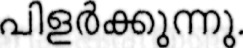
പിളര്‍ക്കുന്നു.
